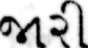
જારી
